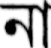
না
